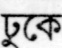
ঢুকে
